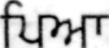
ਪਿਆ
